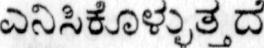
ಎನಿಸಿಕೊಳ್ಳುತ್ತದೆ
